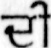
ਦੀ
